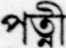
পত্নী
